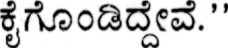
ಕೈಗೊಂಡಿದ್ದೇವೆ."
